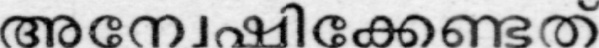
അന്വേഷിക്കേണ്ടത്
